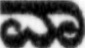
ವಾ
